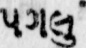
પગલું
